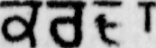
ਕਰਦਾ
